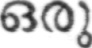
ഒരു
